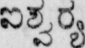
ಐಶ್ವರ್‍ಯ
